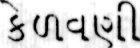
કેળવણી
